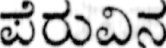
ಪೆರುವಿನ
